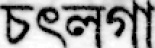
চৎলগা
